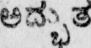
ಅದ್ಭುತ
